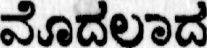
ಮೊದಲಾದ
